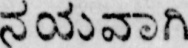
ನಯವಾಗಿ
